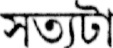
সত্যটা
